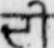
ਦੀ
